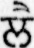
ਲੈ
